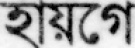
হায়গে
